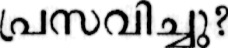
പ്രസവിച്ചു?
